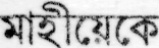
মাহীয়েকে
